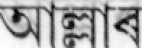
আল্লাৰ
